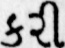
કરી
